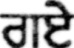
ਗਏ
